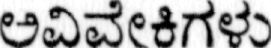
ಅವಿವೇಕಿಗಳು
